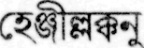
হেঞ্জীল্লক্কনু
